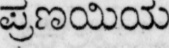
ಪ್ರಣಯಿಯ
